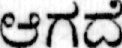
ಆಗದೆ
